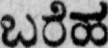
ಬರೆಹ
